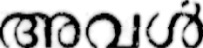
അവള്‍
